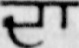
ਦਾ
